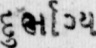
દુર્ભાગ્ય
